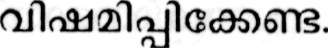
വിഷമിപ്പിക്കേണ്ട.
